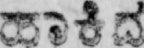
ಹಾಕಿದ
